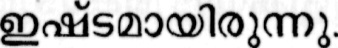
ഇഷ്ടമായിരുന്നു.
